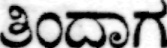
ತಿಂದಾಗ
